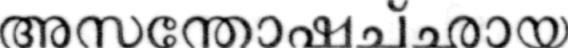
അസന്തോഷച്ഛായ
